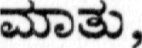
ಮಾತು,
